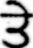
ਤੇ
